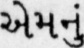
એમનું
